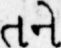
તને
